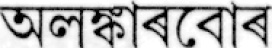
অলঙ্কাৰবোৰ
